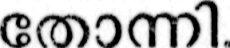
തോന്നി.
